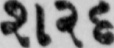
શરદ
